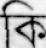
কি
